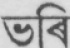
ভৰি
